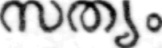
സത്യം
